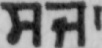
ਸਜਾ
